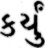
કર્યું
